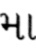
મા
